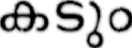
കടും
